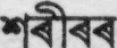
শৰীৰৰ
